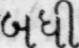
બધી
